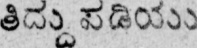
ತಿದ್ದುಪಡಿಯು
